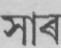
সাৰ
